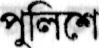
পুলিশে
